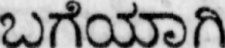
ಬಗೆಯಾಗಿ
